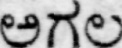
ಅಗಲ
